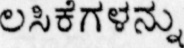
ಲಸಿಕೆಗಳನ್ನು
